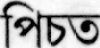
পিচত
